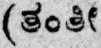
(ತಂತೇ
